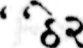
"ઠેર
